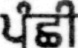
ਪੰਛੀ
